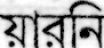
য়ারনি
